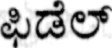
ಫಿಡೆಲ್
